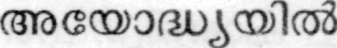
അയോദ്ധ്യയില്‍
